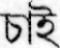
চাই
